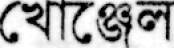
খোঞ্জেল
